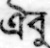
ঐবু
